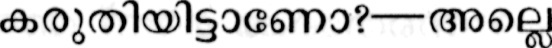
കരുതിയിട്ടാണോ?-അല്ലെ
